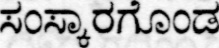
ಸಂಸ್ಕಾರಗೊಂಡ
